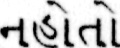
નહોતો
